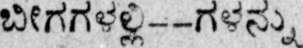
ಬೀಗಗಳಲ್ಲಿ--ಗಳನ್ನು
